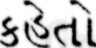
કહેતો
